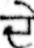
ਦੇ
